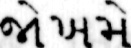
જોખમે
